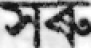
সৰু
